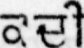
ਕਦੀ
